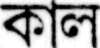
কাল
